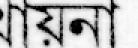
থায়না
